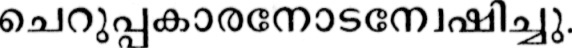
ചെറുപ്പകാരനോടന്വേഷിച്ചു.
